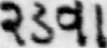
રડવા
